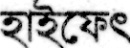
হাইফেৎ
